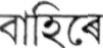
বাহিৰে
